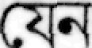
যেন
